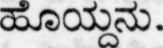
ಹೊಯ್ದನು.
